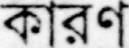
কারণ
